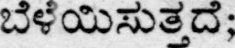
ಬೆಳೆಯಿಸುತ್ತದೆ;
